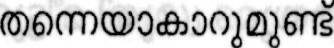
തന്നെയാകാറുമുണ്ട്
